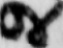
જ
